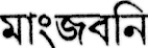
মাংজবনি
